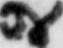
જ
